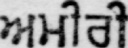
ਅਮੀਰੀ
